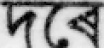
দৰে
